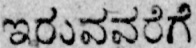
ಇರುವವರೆಗೆ
